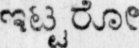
ಇಟ್ಟರೋ
